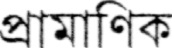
প্রামাণিক
